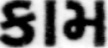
કામ
